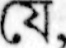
যে,
